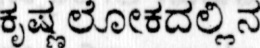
ಕೃಷ್ಣಲೋಕದಲ್ಲಿನ
